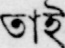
তাই
